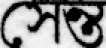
সেন্ত
